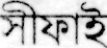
সীফাই
